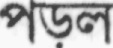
পড়ল
